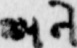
અને
